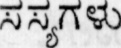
ಸಸ್ಯಗಳು
